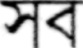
সব
